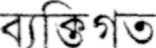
ব্যক্তিগত
